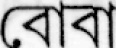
বোবা
